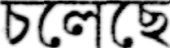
চলেছে
